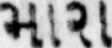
મારા
